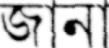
জানা
